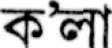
ক'লা
